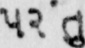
પરંતુ
